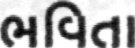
ભવિતા
